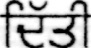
ਦਿੱਤੀ
